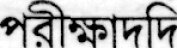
পরীক্ষাদদি
